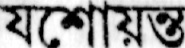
যশোয়ন্ত
